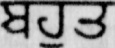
ਬਹੁਤ
